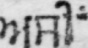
ਅਸੀਂ
